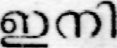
ഇനി
